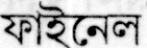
ফাইনেল
